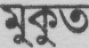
মুকুত
